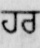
ਹਰ
